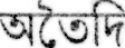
অতৈদি
